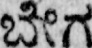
ಬೇಗ
